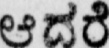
ಆದರೆ
